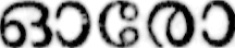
ഓരോ
